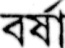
বর্ষা
